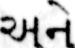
અને
